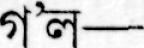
গ'ল-
